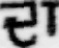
ਦਾ
